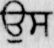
ਉਸ
